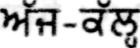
ਅੱਜ-ਕੱਲ੍ਹ
